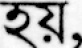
হয়,
